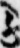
કે
